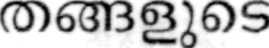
തങ്ങളുടെ
